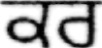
ਕਰ
